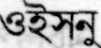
ওইসনু
